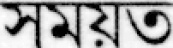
সময়ত
